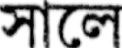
সালে
